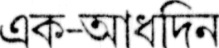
এক-আধদিন
